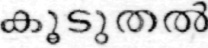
കൂടുതല്‍
